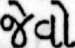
જેવો
